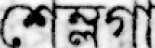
শেম্লগা
